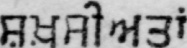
ਸ਼ਖ਼ਸੀਅਤਾਂ
